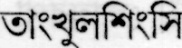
তাংখুলশিংসি
